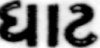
ધાટ
